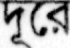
দূরে
